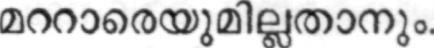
മററാരെയുമില്ലതാനും.
